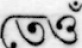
তেওঁ
